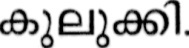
കുലുക്കി.
